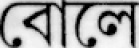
বোলে
